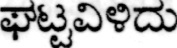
ಘಟ್ಟವಿಳಿದು
